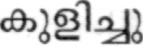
കുളിച്ചു
